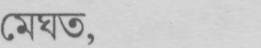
মেঘত,
